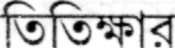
তিতিক্ষার
